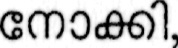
നോക്കി,
